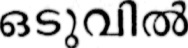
ഒടുവില്‍
